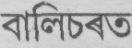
বালিচৰত
